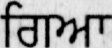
ਗਿਆ
